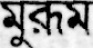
মুরূম
